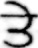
ਤੇ
